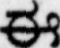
ಈ
